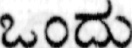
ಒಂದು
